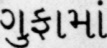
ગુફામાં
